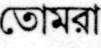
তোমরা
